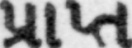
પ્રાપ્ત
